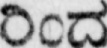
ರಿಂದ
